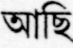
আছি
